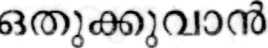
ഒതുക്കുവാന്‍
